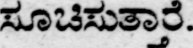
ಸೂಚಿಸುತ್ತಾರೆ.
